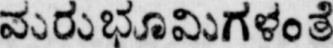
ಮರುಭೂಮಿಗಳಂತೆ
